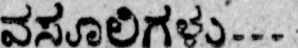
ವಸೂಲಿಗಳು...
